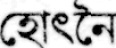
হোৎনৈ
